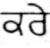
ਕਰੇ
